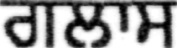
ਗਲਾਸ
